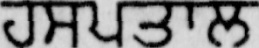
ਹਸਪਤਾਲ
